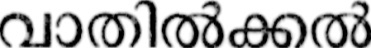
വാതില്‍ക്കല്‍
